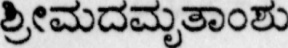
ಶ್ರೀಮದಮೃತಾಂಶು
